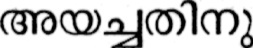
അയച്ചതിനു
